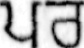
ਪਰ
